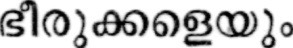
ഭീരുക്കളെയും
